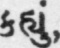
કહ્યું,
